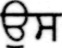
ਉਸ
